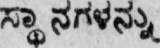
ಸ್ಥಾನಗಳನ್ನು
